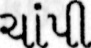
ચાંપી
